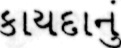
કાયદાનું
